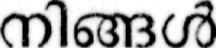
നിങ്ങള്‍
